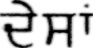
ਦੇਸਾਂ
